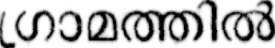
ഗ്രാമത്തില്‍
